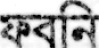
ফবনি
